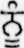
ਨੂੰ
